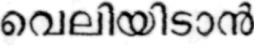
വെലിയിടാന്‍
